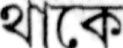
থাকে
